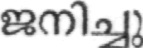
ജനിച്ചു.
